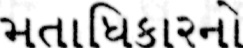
મતાધિકારનો
